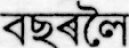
বছৰলৈ
